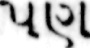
પણ
